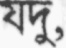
যদু,
